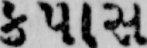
કપાસ
